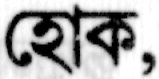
হোক,
